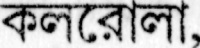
কলরোলা,
